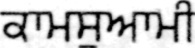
ਕਾਮਸੁਆਮੀ
